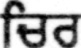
ਚਿਰ
